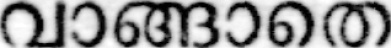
വാങ്ങാതെ
